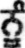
ਨੂੰ
